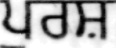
ਪੁਰਸ਼
